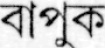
বাপুক
